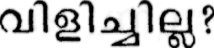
വിളിച്ചില്ല?
